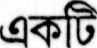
একটি
